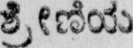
ಶ್ರೇಣಿಯ
